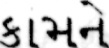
કામને
